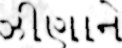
ઝીણાને
